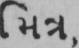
મિત્ર,
